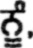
ਨੂੰ,
